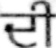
ਦੀ
